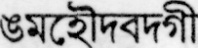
ঙমহৌদবদগী
